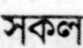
সকল
